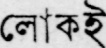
লোকই
